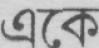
একে
